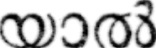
യാല്‍
